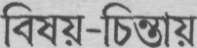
বিষয়-চিন্তায়
